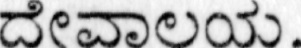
ದೇವಾಲಯ.
